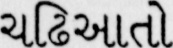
ચઢિઆતો
